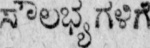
ಸೌಲಭ್ಯಗಳಿಗೆ
